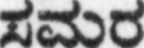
ಸಮರ
